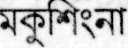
মকুশিংনা
